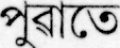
পুৱাতে
